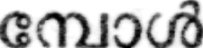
മ്പോള്‍
